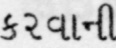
કરવાની
